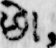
છો,
